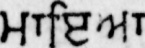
ਮਾਇਆ
